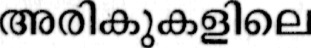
അരികുകളിലെ
